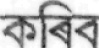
কৰিব
